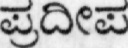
ಪ್ರದೀಪ
